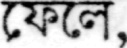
ফেলে,
